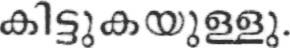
കിട്ടുകയുള്ളു.
